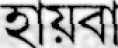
হায়বা
